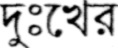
দুঃখের
